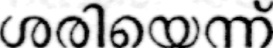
ശരിയെന്ന്
